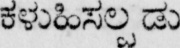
ಕಳುಹಿಸಲ್ಪಡು
